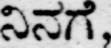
ನಿನಗೆ,
